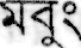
মবুং
